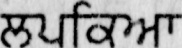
ਲਪਕਿਆ
